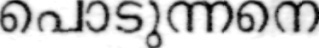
പൊടുന്നനെ
